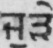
ਜੁੜੇ
